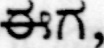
ಈಗ,
